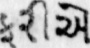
ફરીએ
